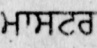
ਮਾਸਟਰ
